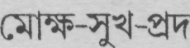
মোক্ষ-সুখ-প্ৰদ
